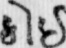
કોઈ
